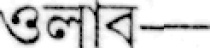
ওলাব-
